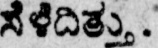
ಸೆಳೆದಿತ್ತು.
